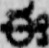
ಈ
